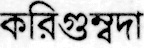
করিগুম্বদা
